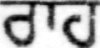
ਰਾਹ
